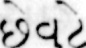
છેવટે
